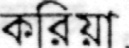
করিয়া
